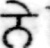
ਨੇ
